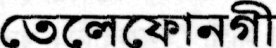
তেলেফোনগী
